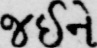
જઈને
